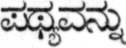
ಪಥ್ಯವನ್ನು
